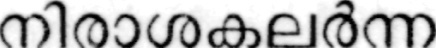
നിരാശകലര്‍ന്ന
